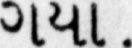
ગયા.
